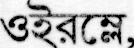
ওইরম্লে,
